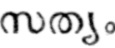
സത്യം
